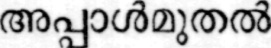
അപ്പാള്‍മുതല്‍
